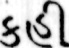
કહી
